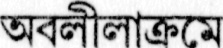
অবলীলাক্রমে
